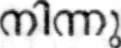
നിന്നു
